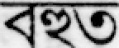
বহুত
